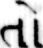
તો
